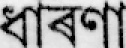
ধাৰণা
